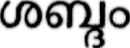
ശബ്ദം
